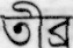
তীব্র
